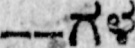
-ಗಳ
